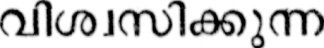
വിശ്വസിക്കുന്ന
